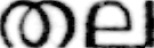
തല
